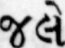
જલે
